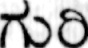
ಗುರಿ
